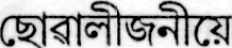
ছোৱালীজনীয়ে
